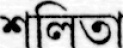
শলিতা
